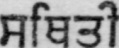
ਸਥਿਤੀ
